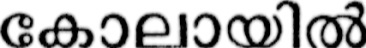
കോലായില്‍
